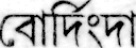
বোর্দিংদা
